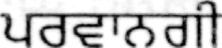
ਪਰਵਾਨਗੀ
